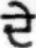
ਦੇ
